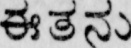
ಈತನು
